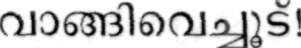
വാങ്ങിവെച്ചൂട്!
